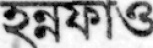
হন্নফাও
